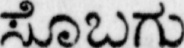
ಸೊಬಗು
